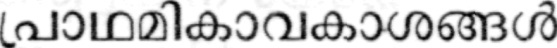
പ്രാഥമികാവകാശങ്ങള്‍
